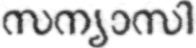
സന്യാസി
